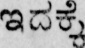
ಇದಕ್ಕೆ
